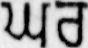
ਘਰ
